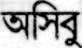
অসিবু
